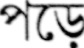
পড়ে
